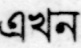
এখন
